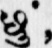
છું,
